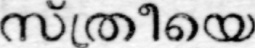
സ്ത്രീയെ
